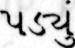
પડ્યું
